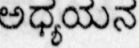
ಅಧ್ಯಯನ
